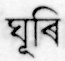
ঘূৰি
